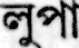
লুপা
